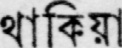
থাকিয়া
